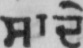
ਸਾਦੇ
